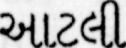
આટલી
